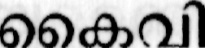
കൈവി
